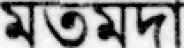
মতমদা
